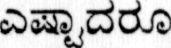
ಎಷ್ಟಾದರೂ
